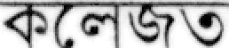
কলেজত
